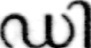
ഡി
